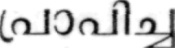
പ്രാപിച്ച
